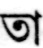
তা
